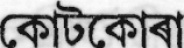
কোটকোৰা
